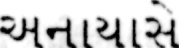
અનાયાસે
